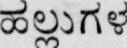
ಹಲ್ಲುಗಳ
